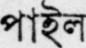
পাইল
